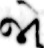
જો
